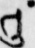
તું
